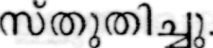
സ്തുതിച്ചു.
